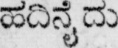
ಹದಿನೈದು
